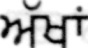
ਅੱਖਾਂ
